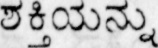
ಶಕ್ತಿಯನ್ನು
